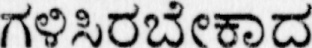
ಗಳಿಸಿರಬೇಕಾದ
